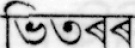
ভিতৰৰ
